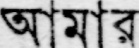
আমার
